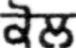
ਕੋਲ
